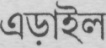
এড়াইল
